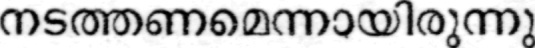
നടത്തണമെന്നായിരുന്നു
